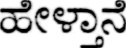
ಹೇಳ್ತಾನೆ
